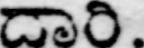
ದಾರಿ.
